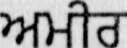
ਅਮੀਰ
